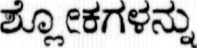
ಶ್ಲೋಕಗಳನ್ನು
